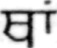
ਥਾਂ
